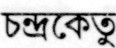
চন্দ্রকেতু
